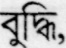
বুদ্ধি,
